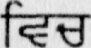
ਵਿਚ
